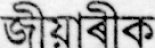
জীয়াৰীক
